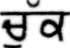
ਚੁੱਕ
